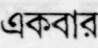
একবার
